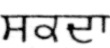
ਸਕਦਾ
